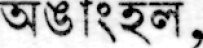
অঙাংহল,
